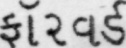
ફૉરવર્ડ
